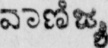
ವಾಣಿಜ್ಯ
